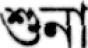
শুনা
